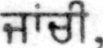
ਜਾਂਚੀ,
